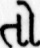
તો
